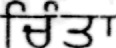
ਚਿੰਤਾ
